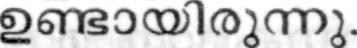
ഉണ്ടായിരുന്നു.
